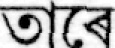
তাৰে
